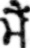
ਮੈਂ
